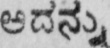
ಅದನ್ನು
